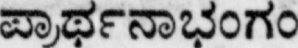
ಪ್ರಾರ್ಥನಾಭಂಗಂ
